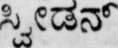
ಸ್ವೀಡನ್
